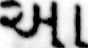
આ
